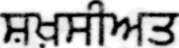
ਸ਼ਖ਼ਸੀਅਤ
